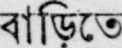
বাড়িতে
